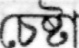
চেষ্টা
